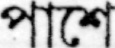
পাশে
